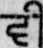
ਵੀ
